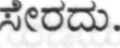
ಸೇರದು.
